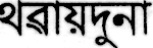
থৱায়দুনা
